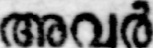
അവര്‍
